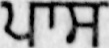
ਪਾਸ
